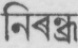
নিৰন্ধ্ৰ
